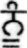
ਨੂੰ
